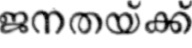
ജനതയ്ക്ക്
